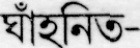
ঘাঁহনিত-
